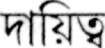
দায়িত্ব
